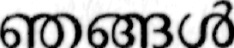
ഞങ്ങള്‍
